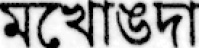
মখোঙদা
